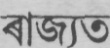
ৰাজ্যত
